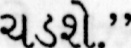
ચડશે."
